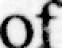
of
